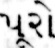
પૂરો
